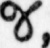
જ,
